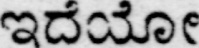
ಇದೆಯೋ
